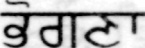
ਭੋਗਣਾ
